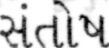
સંતોષ
